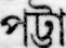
পট্টা
